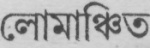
লোমাঞ্চিত
